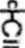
ਨੂੰ
